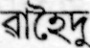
ৱাহৈদু
